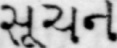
સૂચન
